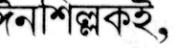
ঈনশিল্লকই,
